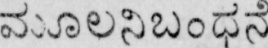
ಮೂಲನಿಬಂಧನೆ
